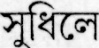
সুধিলে
